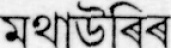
মথাউৰিৰ
